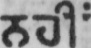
ਨਹੀਂ
